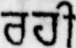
ਰਹੀ
